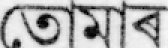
তোমাৰ
